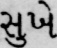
સુખે
